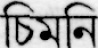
চিমনি
